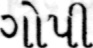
ગોપી
